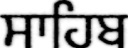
ਸਾਹਿਬ
